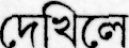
দেখিলে
